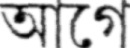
আগে
